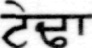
ਟੇਢਾ
